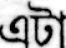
এটা
